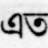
এত
